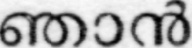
ഞാന്‍
